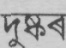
দুষ্কৰ
